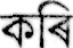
কৰি
